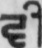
ਵੀ
